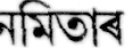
নমিতাৰ
